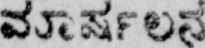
ಮಾರ್ಷಲನ
